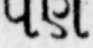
પણ
